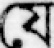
যে
